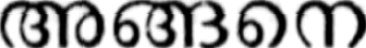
അങ്ങനെ
